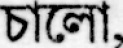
চালো,
